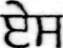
ਏਸ
